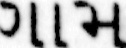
ગામ
